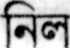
নিল
